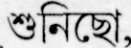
শুনিছো,
